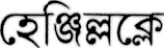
হেঞ্জিল্লক্লে
